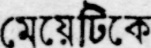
মেয়েটিকে
